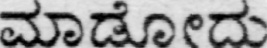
ಮಾಡೋದು
